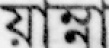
য়াম্না
